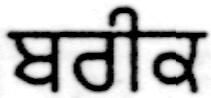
ਬਰੀਕ
